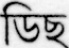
ডিছ
